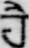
ਹੈ
